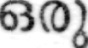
ഒരു
